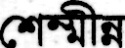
শেম্মীন্ন
